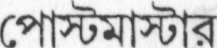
পোস্টমাস্টার
